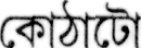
কোঠাটো
